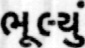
ભૂલ્યું
